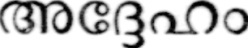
അദ്ദേഹം
